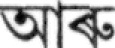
আৰু
